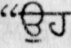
''ਉਹ
